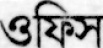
ওফিস
